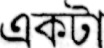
একটা
